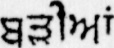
ਬੜੀਆਂ
